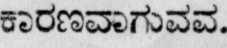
ಕಾರಣವಾಗುವವ.
